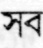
সব
